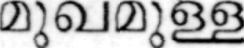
മുഖമുള്ള
